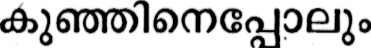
കുഞ്ഞിനെപ്പോലും
